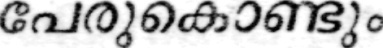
പേരുകൊണ്ടും
